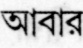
আবার
